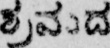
ಶ್ರಮದ
